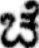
ಚೆ
